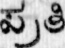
ಪ್ರತಿ
